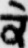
ਕੇ
